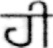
ਹੀ
